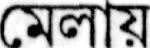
মেলায়
